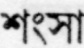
শংসা
